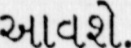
આવશે.
